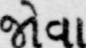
જોવા
